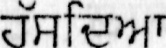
ਹੱਸਦਿਆ
